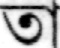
তা
